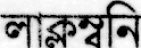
লাক্লম্বনি
